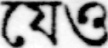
যেও
